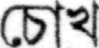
চোখ
